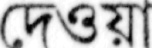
দেওয়া
